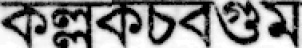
কল্লকচবগুম
